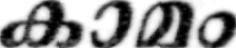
കാമം
